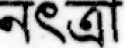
নৎত্রা
